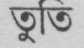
তুতি
